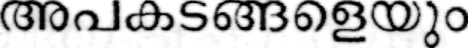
അപകടങ്ങളെയും
